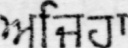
ਅਜਿਹਾ
